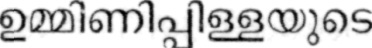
ഉമ്മിണിപ്പിള്ളയുടെ
